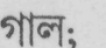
গাল;
